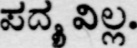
ಪದ್ಯವಿಲ್ಲ.
